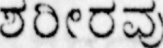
ಶರೀರವು
